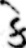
કે
